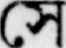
সে
